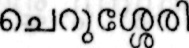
ചെറുശ്ശേരി
